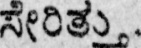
ಸೇರಿತ್ತು.
